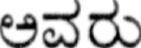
ಅವರು
